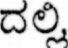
ದಲ್ಲಿ,
